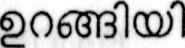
ഉറങ്ങിയി
